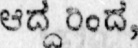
ಆದ್ದರಿಂದ,
